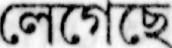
লেগেছে
